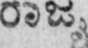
ರಾಜ್ಯ
